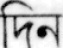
দিন
